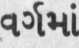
વર્ગમાં
